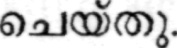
ചെയ്തു.
